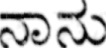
ನಾನು
